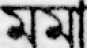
মমা
